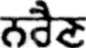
ਨਰੈਣ
